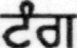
ਟੰਗ
